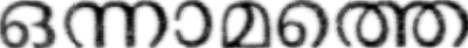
ഒന്നാമത്തെ
